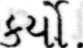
કર્યો.
